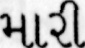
મારી
